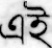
এই
